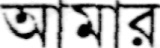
আমার
